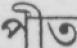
পীত
